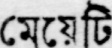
মেয়েটি
